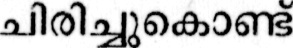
ചിരിച്ചുകൊണ്ട്
